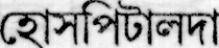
হোসপিটালদা
